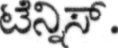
ಟೆನ್ನಿಸ್.
